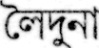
লৈদুনা
